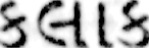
કલાક
